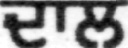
ਦਾਲ
